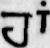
ਹਾਂ
